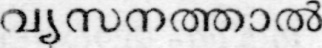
വ്യസനത്താല്‍
